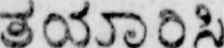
ತಯಾರಿಸಿ
